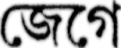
জেগে
